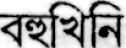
বহুখিনি
